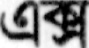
এক্স
